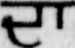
ਦਾ
